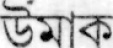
উমাক
